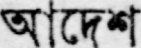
আদেশ
